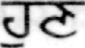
ਹੁਣ
